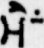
ਮੈਂ
